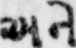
અને
